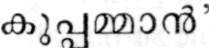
കുപ്പമ്മാന്‍'
